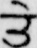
ਤੇ
